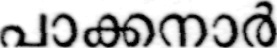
പാക്കനാര്‍
